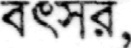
বৎসর,
